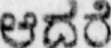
ಆದರೆ
